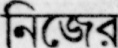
নিজের
